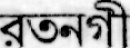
রতনগী
